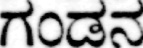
ಗಂಡನ
